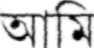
আমি
